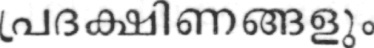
പ്രദക്ഷിണങ്ങളും
